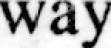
way
